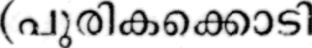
(പുരികക്കൊടി
